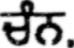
ਚੰਨ,
